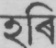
হৰি
